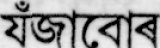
যঁজাবোৰ
